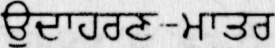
ਉਦਾਹਰਣ-ਮਾਤਰ
